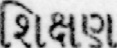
શિક્ષણ
